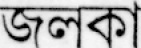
জলকা
